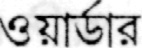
ওয়ার্ডার
